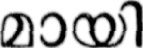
മായി
